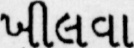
ખીલવા
